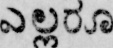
ಎಲ್ಲರೂ
